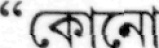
"কোনো
